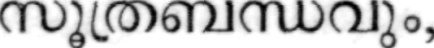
സൂത്രബന്ധവും,
